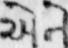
એને
